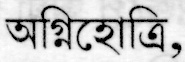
অগ্নিহোত্রি,
